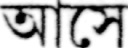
আসে
